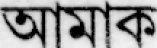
আমাক
